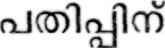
പതിപ്പിന്
